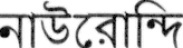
নাউরোন্দি
